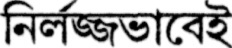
নির্লজ্জভাবেই
